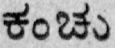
ಕಂಚು
